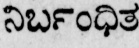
ನಿರ್ಬಂಧಿತ
